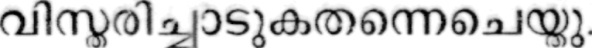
വിസ്തരിച്ചാടുകതന്നെചെയ്തു.
